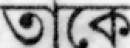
তাকে
